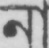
না
